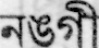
নঙগী
